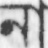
না
